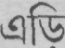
এড়ি
